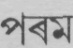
পৰম
